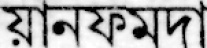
য়ানফমদা
